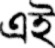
এই
